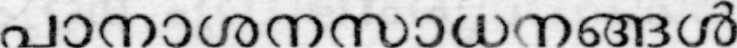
പാനാശനസാധനങ്ങള്‍
